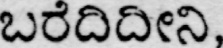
ಬರೆದಿದೀನಿ,
